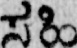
ಸಹಿ
